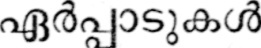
ഏര്‍പ്പാടുകള്‍
